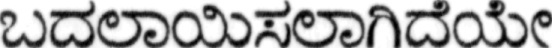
ಬದಲಾಯಿಸಲಾಗಿದೆಯೇ
